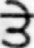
ਤੇ
